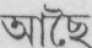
আছৈ
